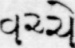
વચ્ચે
